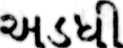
અડધી
